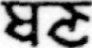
ਬਣ
